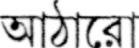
আঠারো
